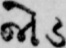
જોડ
